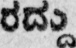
ರದ್ದು
